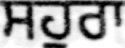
ਸਹੁਰਾ
